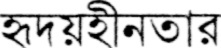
হৃদয়হীনতার
